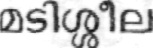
മടിശ്ശീല
